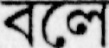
বলে
